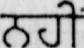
ਨਹੀਂ
